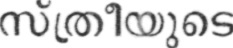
സ്ത്രീയുടെ
